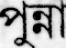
পুন্না
